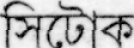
সিটোক
